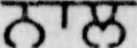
ਨਾਲ
